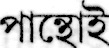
পান্থোই
